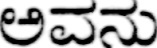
ಅವನು
